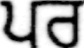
ਪਰ
